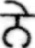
ਨੇ
